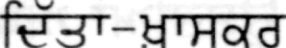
ਦਿੱਤਾ-ਖ਼ਾਸਕਰ
